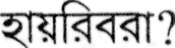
হায়রিবরা?
